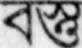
বস্তু
